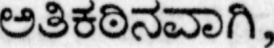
ಅತಿಕಠಿನವಾಗಿ,
